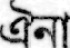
ঐনা
